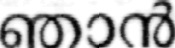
ഞാന്‍
